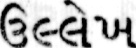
ઉલ્લેખ
